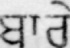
ਬਾਰੇ
